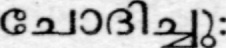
ചോദിച്ചു:
